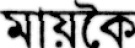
মায়কৈ
